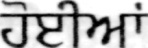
ਹੋਈਆਂ
